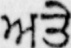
ਅਤੇ
